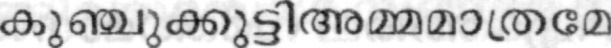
കുഞ്ചുക്കുട്ടിഅമ്മമാത്രമേ
